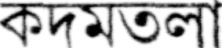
কদমতলা
